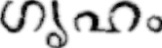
ഗൃഹം
